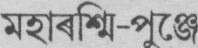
মহাৰশ্মি-পুঞ্জে
